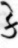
કે
